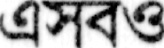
এসবও
